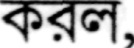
করল,
